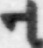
ન
